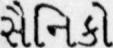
સૈનિકો
